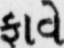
ફાવે
